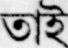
তাই
